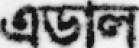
এডাল
